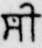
ਸੀ
